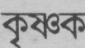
কৃষ্ণক
